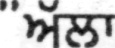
''ਅੱਲਾ
